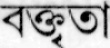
বক্তৃতা
